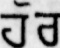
ਹੋਰ
